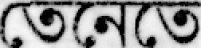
তেনেতে
